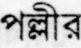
পল্লীর
